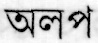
অলপ
